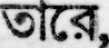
তারে,
